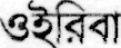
ওইরিবা
